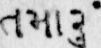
તમારું
